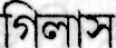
গিলাস
